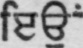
ਇਉਂ
